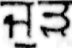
ਜੁੜ
